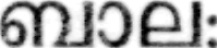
ബാല:
